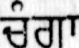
ਚੰਗਾ
